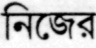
নিজের
